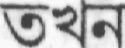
তখন
